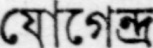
যোগেন্দ্র
